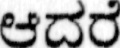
ಆದರೆ
